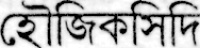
হৌজিকসিদি
